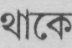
থাকে
